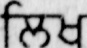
ਲਿਖ
